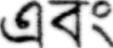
এবং
